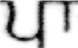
ਪਾ
